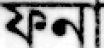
ফনা
